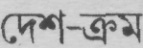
দেশ-ক্ৰম
